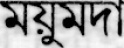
ময়ুমদা
